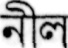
নীল
